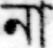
না
